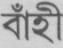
বাঁহী
